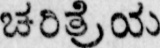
ಚರಿತ್ರೆಯ
